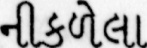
નીકળેલા
